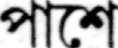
পাশে
